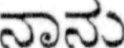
ನಾನು
